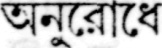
অনুরোধে
